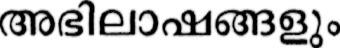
അഭിലാഷങ്ങളും
